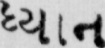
ધ્યાન
